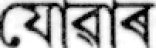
যোৱাৰ
